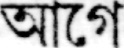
আগে
